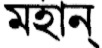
মহান্
